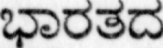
ಭಾರತದ
